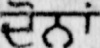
ਦੋਨਾਂ
